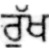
ਰੁੱਖ
